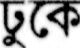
ঢুকে
